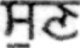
ਸੁਣ
